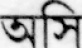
অসি
